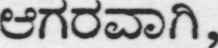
ಆಗರವಾಗಿ,
